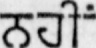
ਨਹੀਂ
